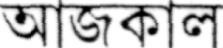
আজকাল
